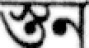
স্তন
